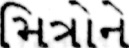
મિત્રોને
